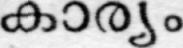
കാര്യം
